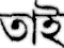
তাই
